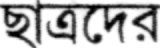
ছাত্রদের
